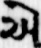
એ
